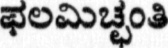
ಫಲಮಿಚ್ಛಂತಿ
